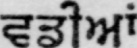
ਵਡੀਆਂ
